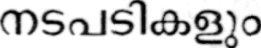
നടപടികളും
